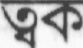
ত্বক
